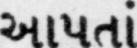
આપતાં
